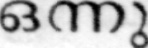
ഒന്നു
